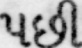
પછી
